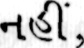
નહીં,
